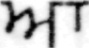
ਆ
